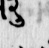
ખરું
